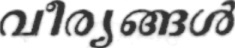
വീര്യങ്ങള്‍
